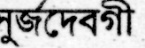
সুর্জদেবগী
